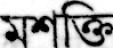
মশক্তি
